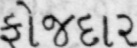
ફોજદાર
